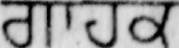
ਗਾਹਕ
